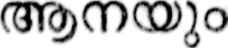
ആനയും
